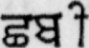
ਛਬੀ
